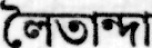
লৈতান্দা
